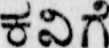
ಕವಿಗೆ
